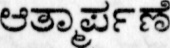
ಆತ್ಮಾರ್ಪಣೆ
